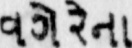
વગેરેના
